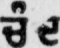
ਚੰਦ
